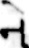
ને
